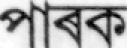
পাৰক
